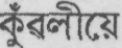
কুঁৱলীয়ে
